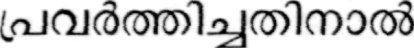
പ്രവര്‍ത്തിച്ചതിനാല്‍
